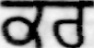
ਕਰ
